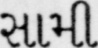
સામી
